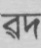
ৱদ
